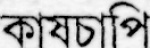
কাষচাপি
